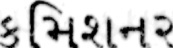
કમિશનર
